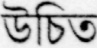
উচিত
